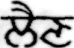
ਲੈਣ
